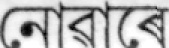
নোৱাৰে
